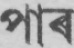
পাৰ
